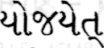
યોજયેત્
